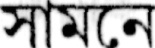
সামনে
